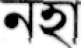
নহা
